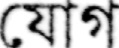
যোগ
